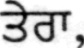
ਤੇਰਾ,
